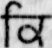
ਕਿ
